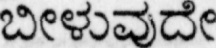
ಬೀಳುವುದೇ
